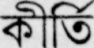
কীর্তি
